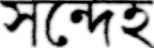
সন্দেহ
